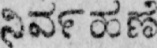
ನಿರ್ವಹಣೆ
